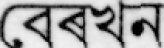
বেৰখন
